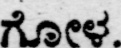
ಗೋಳ.
